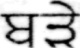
ਬੜੇ
